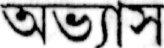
অভ্যাস
